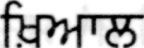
ਖ਼ਿਆਲ
